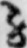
કે
